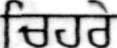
ਚਿਹਰੇ
